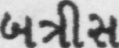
બત્રીસ
